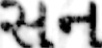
સન
